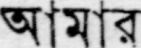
আমার
